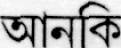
আনকি
